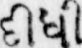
દીધી
